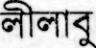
লীলাবু
